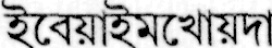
ইবেয়াইমখোয়দা
